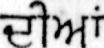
ਦੀਆਂ
